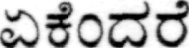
ಏಕೆಂದರೆ
